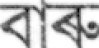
বাৰু
